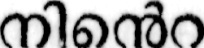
നിന്റെ
